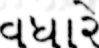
વધારે
